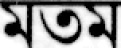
মতম
